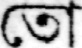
তো
